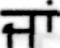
ਜਾਂ
